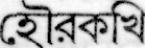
হৌরকখি
